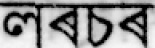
লৰচৰ
